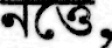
নত্তে,
